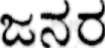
ಜನರ
